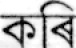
কৰি
